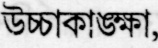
উচ্চাকাঙ্ক্ষা,
